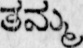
ತಮ್ಮ
